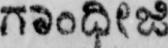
ಗಾಂಧೀಜಿ
